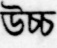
উচ্চ
